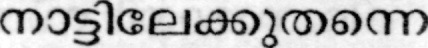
നാട്ടിലേക്കുതന്നെ
